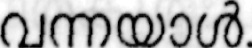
വന്നയാള്‍.
